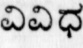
ವಿವಿಧ
